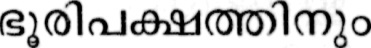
ഭൂരിപക്ഷത്തിനും
